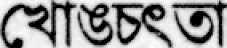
খোঙচৎতা
